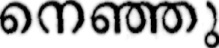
നെഞ്ഞു
